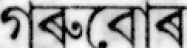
গৰুবোৰ
